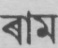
ৰাম
